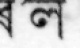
ৰ'ল
